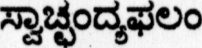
ಸ್ವಾಚ್ಛಂದ್ಯಫಲ೦
